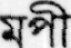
মপী
